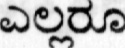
ಎಲ್ಲರೂ
